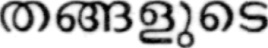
തങ്ങളുടെ
